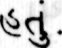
હતું.
